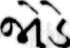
જોડે
